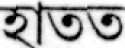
হাতত
